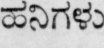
ಹನಿಗಳು
